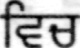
ਵਿਚ
